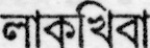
লাকখিবা
